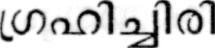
ഗ്രഹിച്ചിരി
